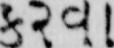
કરવા
